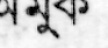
অমুক
